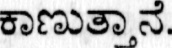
ಕಾಣುತ್ತಾನೆ.
